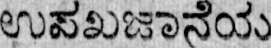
ಉಪಖಜಾನೆಯ
